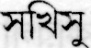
সখিসু
